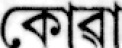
কোৱা
